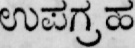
ಉಪಗ್ರಹ
